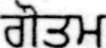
ਗੌਤਮ
